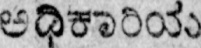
ಅಧಿಕಾರಿಯ
